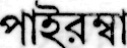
পাইরম্বা
